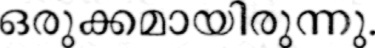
ഒരുക്കമായിരുന്നു.
